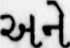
અને
